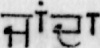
ਜਾਂਦਾ
